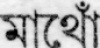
মাথোঁ
